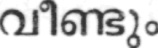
വീണ്ടും
